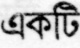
একটি
